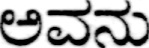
ಅವನು
